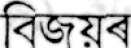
বিজয়ৰ
